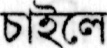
চাইলে
